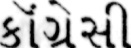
કૉંગ્રેસી
